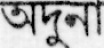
অদুনা
